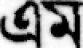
এম
